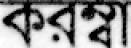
করম্বা
